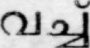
വച്ച്
